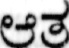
ಆತ
